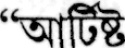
"আৰ্টিষ্ট
